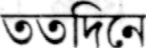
ততদিনে
